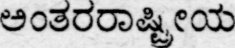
ಅಂತರರಾಷ್ಟ್ರೀಯ
